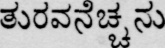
ತುರವನೆಚ್ಚನು
